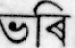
ভৰি
